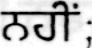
ਨਹੀਂ;
